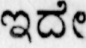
ಇದೇ
